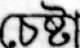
চেষ্টা
